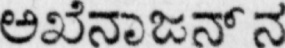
ಅಖೆನಾಜನ್‌ನ
